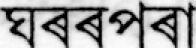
ঘৰৰপৰা
